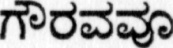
ಗೌರವವೂ
